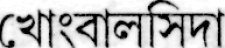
খোংবালসিদা
